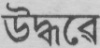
উদ্ধৱে
